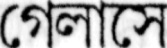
গেলাসে
